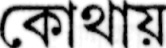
কোথায়
